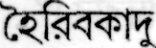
হৈরিবকাদু
